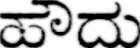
ಹೌದು
